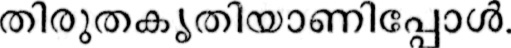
തിരുതകൃതിയാണിപ്പോള്‍.
